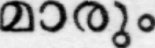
മാരും
